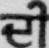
ਦੀ
